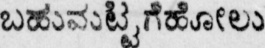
ಬಹುಮಟ್ಟಿಗೆಹೋಲು
